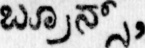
ಬ್ರೂನ್ಸ್,
